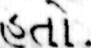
હતો.
